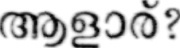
ആളാര്?
